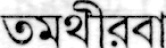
তমথীরবা
